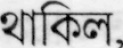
থাকিল,
